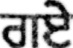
ਗਏ
